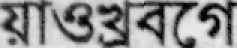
য়াওখ্রবগে
